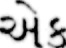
એક
